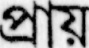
প্রায়
